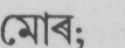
মোৰ;
